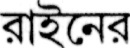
রাইনের
